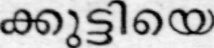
ക്കുട്ടിയെ
